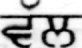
ਵੱਲ
